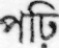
পঢ়ি
